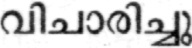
വിചാരിച്ചു
